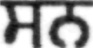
ਸਨ
